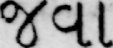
જવા
